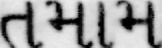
તમામ
